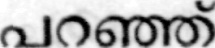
പറഞ്ഞ്
